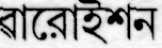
ৱারোইশন
